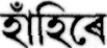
হাঁহিৰে
